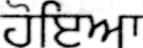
ਹੋਇਆ
